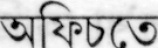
অফিচতে
